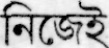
নিজেই
